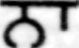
ਨਾ
